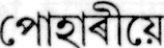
পোহাৰীয়ে
